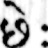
છેઃ
